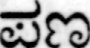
ಪಣ
